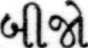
બીજો
